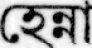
হেন্না
